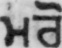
ਮਰੋ
